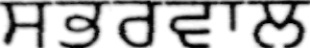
ਸਭਰਵਾਲ
